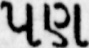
પણ
